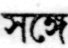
সঙ্গে
